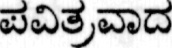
ಪವಿತ್ರವಾದ
